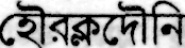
হৌরক্লদৌনি
